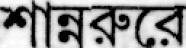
শান্নরুরে
